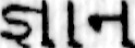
જ્ઞાન
